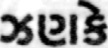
ઝણકે
